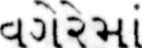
વગેરેમાં
